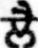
ਲੈ
